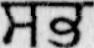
ਸਭ
